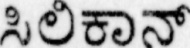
ಸಿಲಿಕಾನ್
